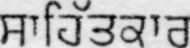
ਸਾਹਿੱਤਕਾਰ
